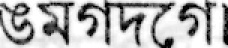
ঙমগদগে।
